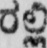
ರಲ್ಲಿ
